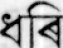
ধৰি
